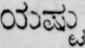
ಯಷ್ಟು
